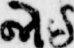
ઝેઇ
